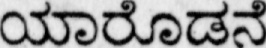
ಯಾರೊಡನೆ
